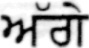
ਅੱਗੇ
